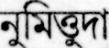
নুমিত্তুদা
